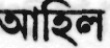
আহিল
